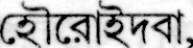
হৌরোইদবা,
